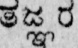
ತಜ್ಞರ
